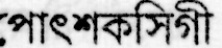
পোৎশকসিগী
